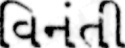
વિનંતી
